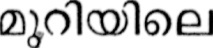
മുറിയിലെ
